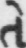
તે
